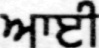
ਆਈ
